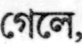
গেলে,
